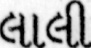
લાલી
